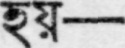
হয়—
